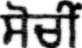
ਸੋਚੀਂ
